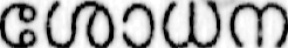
ശോധന
